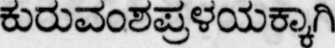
ಕುರುವಂಶಪ್ರಳಯಕ್ಕಾಗಿ
